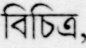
বিচিত্র,
